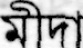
মীদা
